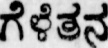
ಗೆಳೆತನ
